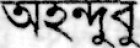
অহন্দুবু
